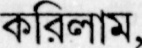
করিলাম,
